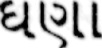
ઘણા
